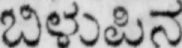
ಬಿಳುಪಿನ
